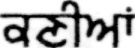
ਕਣੀਆਂ
